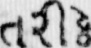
તરીકે
